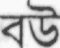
বউ
